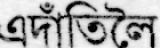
এদাঁতিলৈ
